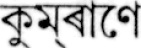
কুম্‌ৰাণে
